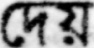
দেয়
